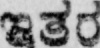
ಇತರ
